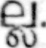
ല്ല.
